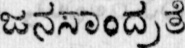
ಜನಸಾಂದ್ರತೆ
